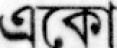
একো
